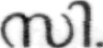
സി.
